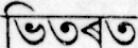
ভিতৰত
